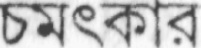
চমৎকার
